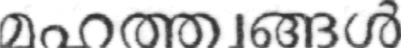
മഹത്ത്വങ്ങള്‍
